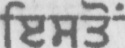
ਇਸਤੋਂ
